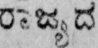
ರಾಜ್ಯದ
